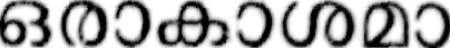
ഒരാകാശമാ
